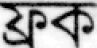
ফ্রক
